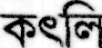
কৎলি
